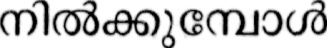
നില്‍ക്കുമ്പോള്‍
